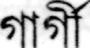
গার্গী
